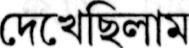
দেখেছিলাম
